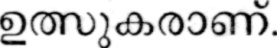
ഉത്സുകരാണ്.
